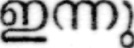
ഇന്നു
